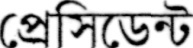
প্রেসিডেন্ট
